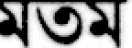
মতম
